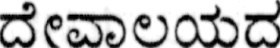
ದೇವಾಲಯದ
